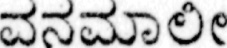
ವನಮಾಲೀ
